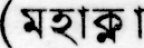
(মহাক্না
